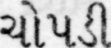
ચોપડી
